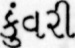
કુંવરી
